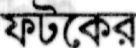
ফটকের
